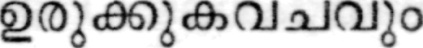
ഉരുക്കുകവചവും
